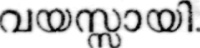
വയസ്സായി.
